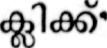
ക്ലിക്ക്
